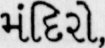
મંદિરો,
